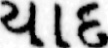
યાદ
